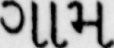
ગામ
